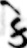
કે
